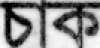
চাক
